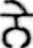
ਨੇ
